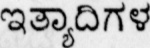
ಇತ್ಯಾದಿಗಳ
